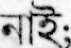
নাই;
